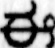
ಈ
